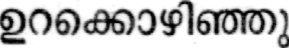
ഉറക്കൊഴിഞ്ഞു
